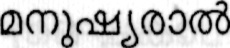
മനുഷ്യരാല്‍
